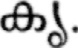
കൃ.
